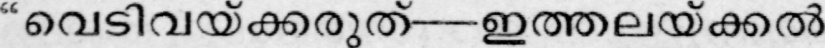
“വെടിവയ്ക്കരുത്-ഇത്തലയ്ക്കല്‍
